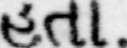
હતા.
